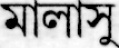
মালাসু
